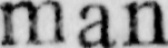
man
